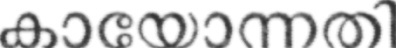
കായോന്നതി
